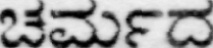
ಚರ್ಮದ
